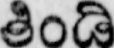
ತಿಂಡಿ
